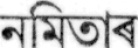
নমিতাৰ
